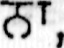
ਨਾ,
